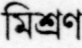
মিশ্রণ
